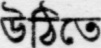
উঠিতে
